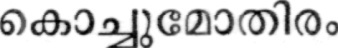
കൊച്ചുമോതിരം
